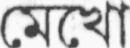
মেখো
